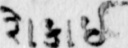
રોકાઈ
